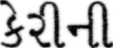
કેરીની
